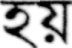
হয়
